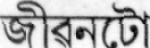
জীৱনটো
